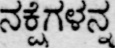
ನಕ್ಷೆಗಳನ್ನ
